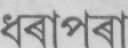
ধৰাপৰা
